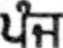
ਪੰਜ
